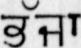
ਭੱਜਾ
